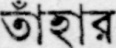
তাঁহার
